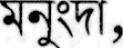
মনুংদা,
